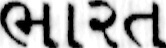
ભારત
